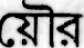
য়ৌর
